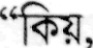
"কিয়,
